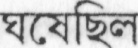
ঘষেছিল
